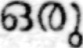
ഒരു
